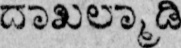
ದಾಖಲ್ಮಾಡಿ
